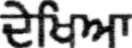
ਦੇਖਿਆ
